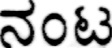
ನಂಟ
